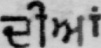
ਦੀਆਂ
